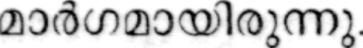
മാര്‍ഗമായിരുന്നു.
